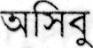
অসিবু
